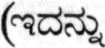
(ಇದನ್ನು
